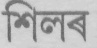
শিলৰ
